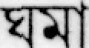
ঘমা
